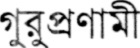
গুরুপ্রণামী
